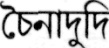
চৈনাদুদি
